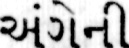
અંગેની
